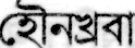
হৌনখ্রবা
